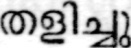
തളിച്ചു
